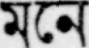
মনে
